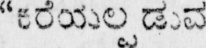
“ಕರೆಯಲ್ಪಡುವ
